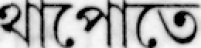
থাপোতে
